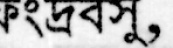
ফংদ্রবসু,
